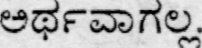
ಅರ್ಥವಾಗಲ್ಲ.
